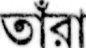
তাঁরা
